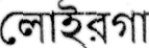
লোইরগা
